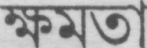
ক্ষমতা
